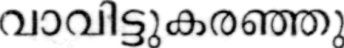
വാവിട്ടുകരഞ്ഞു
